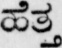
ಹೆತ್ತ
